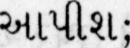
આપીશ;
